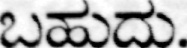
ಬಹುದು.
